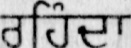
ਰਹਿੰਦਾ
